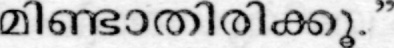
മിണ്ടാതിരിക്കൂ."
